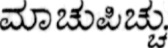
ಮಾಚುಪಿಚ್ಚು.
